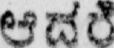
ಆದರೆ
